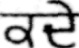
ਕਦੇ
